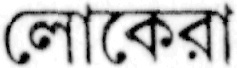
লোকেরা
